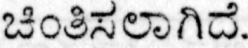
ಚಿಂತಿಸಲಾಗಿದೆ.
